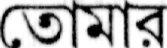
তোমার
